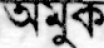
অমুক
